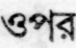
ওপর
